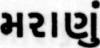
મરાણું
